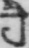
ਹੈ
